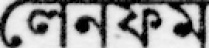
লেনফম
